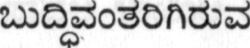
ಬುದ್ಧಿವಂತರಿಗಿರುವ
